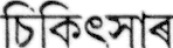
চিকিৎসাৰ
